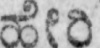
ಹೇರಿ
